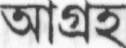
আগ্রহ
